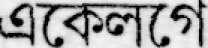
একেলগে
